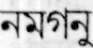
নমগনু
